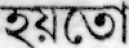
হয়তো
